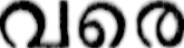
വരെ
